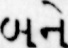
બને
